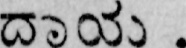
ದಾಯ.
